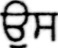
ਉਸ
